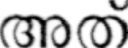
അത്
